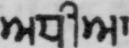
ਅਧੀਆ
